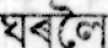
ঘৰলৈ
